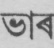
ভাৰ
